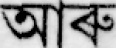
আৰু
